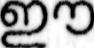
ഈ
